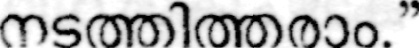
നടത്തിത്തരാം.”
